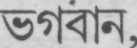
ভগবান,
